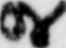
જ
